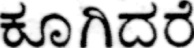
ಕೂಗಿದರೆ
